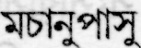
মচানুপাসু
